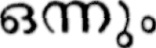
ഒന്നും
